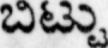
ಬಿಟ್ಟು
